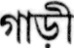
গাড়ী
